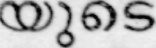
യുടെ
